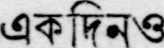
একদিনও
